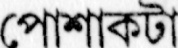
পোশাকটা
